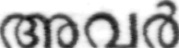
അവര്‍
